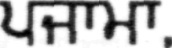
ਪਜਾਮਾ,
